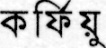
কর্ফিয়ু
